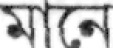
মানে
